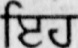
ਇਹ
